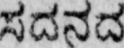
ಸದನದ
